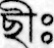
ছীঃ
